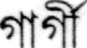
গার্গী
